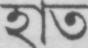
হাত
